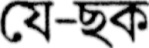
যে-ছক
